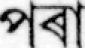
পৰা
